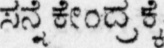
ಸನ್ನೆಕೇಂದ್ರಕ್ಕೆ
